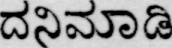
ದನಿಮಾಡಿ
